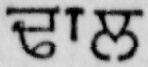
ਢਾਲ
